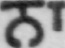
ਨਾ
